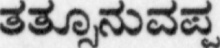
ತತ್ಸೂನುವಪ್ಪ
